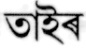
তাইৰ
